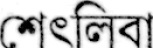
শেৎলিবা
